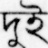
দুই
